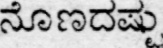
ನೊಣದಷ್ಟು
